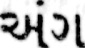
અંગ
